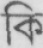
কি
